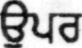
ਉਪਰ
